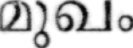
മുഖം
